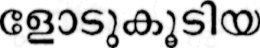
ളോടുകൂടിയ
